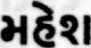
મહેશ
